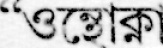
“ওন্থোক্না
